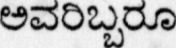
ಅವರಿಬ್ಬರೂ
